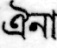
ঐনা
